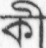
কী
